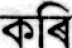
কৰি
